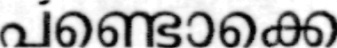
പണ്ടൊക്കെ
